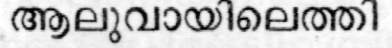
ആലുവായിലെത്തി
